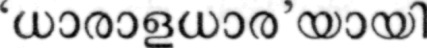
'ധാരാളധാര'യായി
